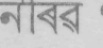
নীৰৱ
